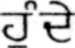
ਹੁੰਦੇ
